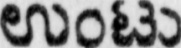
ಉಂಟು
